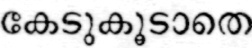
കേടുകൂടാതെ
